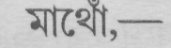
মাথোঁ,-
